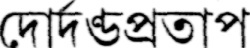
দোর্দণ্ডপ্রতাপ
